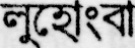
লুহোংবা
